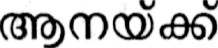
ആനയ്ക്ക്
